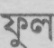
ফুল
